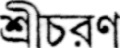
শ্রীচরণ
